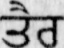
ਤੈਰ
